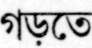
গড়তে
